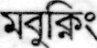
মবু্ক্নিং
